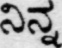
ನಿನ್ನ
